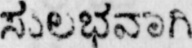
ಸುಲಭವಾಗಿ
